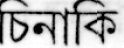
চিনাকি
